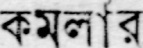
কমলার
